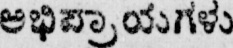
ಅಭಿಪ್ರಾಯಗಳು
